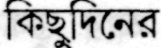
কিছুদিনের
